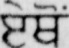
ਏਥੋਂ
